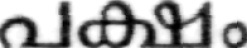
പക്ഷം
